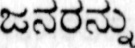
ಜನರನ್ನು
